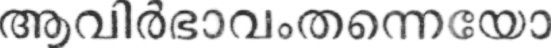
ആവിര്‍ഭാവംതന്നെയോ
